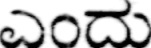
ಎಂದು
